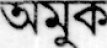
অমুক
